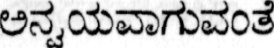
ಅನ್ವಯವಾಗುವಂತೆ
